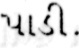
પાડી.
